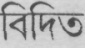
বিদিত
